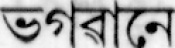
ভগৱানে
